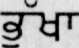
ਭੁੱਖਾ
